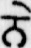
ਨੇ
